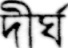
দীর্ঘ
